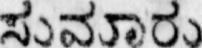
ಸುಮಾರು
